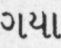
ગયા
